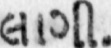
લાગી.
